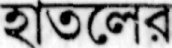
হাতলের
